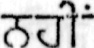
ਨਹੀਂ
